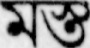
মস্ত
